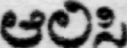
ಆಲಿಸಿ
